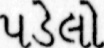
પડેલો
